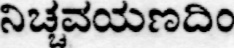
ನಿಚ್ಚವಯಣದಿಂ
